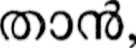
താന്‍,
